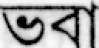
ভবা
